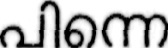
പിന്നെ
